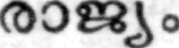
രാജ്യം
